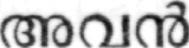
അവന്‍
